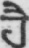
ਹੈ
